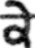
ਕੇ
